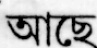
আছে
